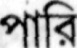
পারি
